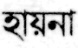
হায়না
